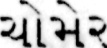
ચોમેર
